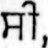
ਸੀ,
